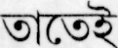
তাতেই
